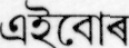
এইবোৰ
